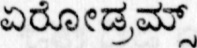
ಏರೋಡ್ರಮ್ಸ್
